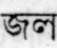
জল
